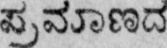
ಪ್ರಮಾಣದ
